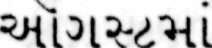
ઑગસ્ટમાં
